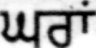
ਘਰਾਂ
